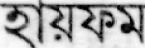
হায়ফম
